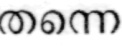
തന്നെ
